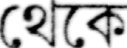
থেকে
